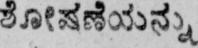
ಶೋಷಣೆಯನ್ನು
